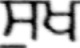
ਸੁਖ
